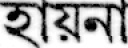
হায়না
